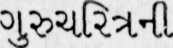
ગુરુચરિત્રની
